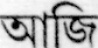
আজি
